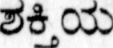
ಶಕ್ತಿಯ
